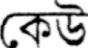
কেউ
